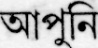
আপুনি
